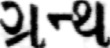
ગ્રન્થ
